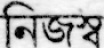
নিজস্ব
